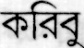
করিবু
